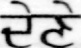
ਦੇਣੇ
